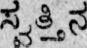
ಸ್ವತ್ತಿನ
